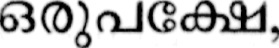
ഒരുപക്ഷേ,
